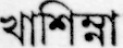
খাশিম্না
